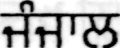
ਜੰਜਾਲ
